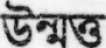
উন্মত্ত
